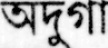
অদুগা
